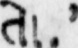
તો.'
